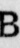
B
